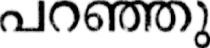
പറഞ്ഞു
